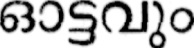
ഓട്ടവും
